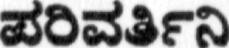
ಪರಿವರ್ತಿನಿ
